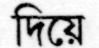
দিয়ে
